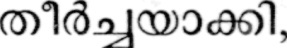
തീര്‍ച്ചയാക്കി,
